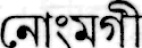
নোংমগী
